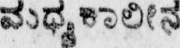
ಮಧ್ಯಕಾಲೀನ
